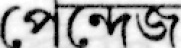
পেন্দেজ
